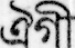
ঐগী
